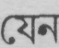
যেন
